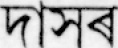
দাসৰ
